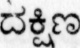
ದಕ್ಷಿಣ
